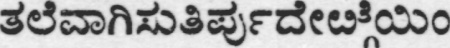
ತಲೆವಾಗಿಸುತಿರ್ಪುದೇೞ್ಗೆಯಿಂ
